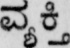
ವ್ಯಕ್ತಿ
